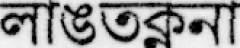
লাঙতক্ননা
